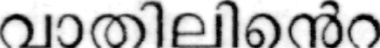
വാതിലിന്റെ
